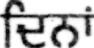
ਦਿਨਾਂ
